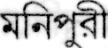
মনিপুরী
